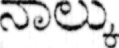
ನಾಲ್ಕು
